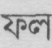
ফল
